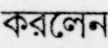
করলেন
